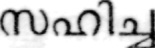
സഹിച്ച
